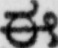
ಈ
